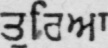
ਤੁਰਿਆ
